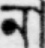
না
